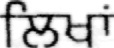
ਲਿਖਾਂ
